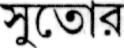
সুতোর
